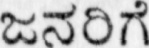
ಜನರಿಗೆ
